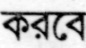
করবে
